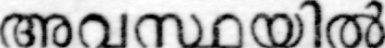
അവസ്ഥയില്‍
